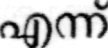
എന്ന്
